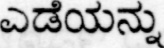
ಎಡೆಯನ್ನು
